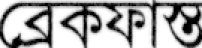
ব্রেকফাস্ত
